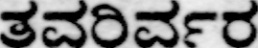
ತವರಿರ್ವರ
